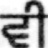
ਵੀ
